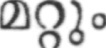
മറ്റും
